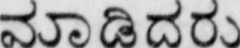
ಮಾಡಿದರು
